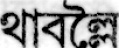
থাবল্লৈ
